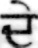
ਦੇ
